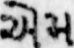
એમ
